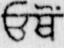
ਓਥੋਂ
